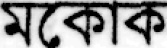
মকোক
